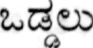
ಒಡ್ಡಲು
